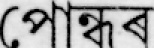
পোন্ধৰ
